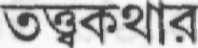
তত্ত্বকথার
